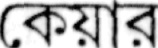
কেয়ার
